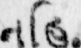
નહિ.
